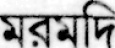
মরমদি
